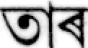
তাৰ
